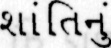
શાંતિનું
